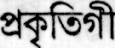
প্রকৃতিগী
